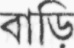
বাড়ি
